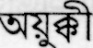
অয়ুক্কী
